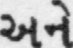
અને
